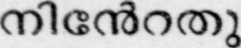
നിന്റേതു
